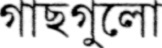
গাছগুলো
